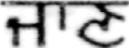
ਜਾਣ
